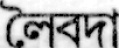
লৈবদা
